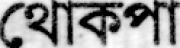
থোকপা
